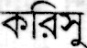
করিসু
